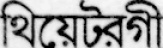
থিয়েটরগী
